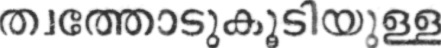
ത്വത്തോടുകൂടിയുള്ള
